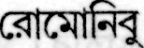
রোমোনিবু
